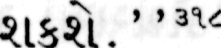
શકશે."૩૧૮
